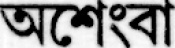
অশেংবা
